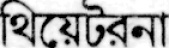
থিয়েটরনা
